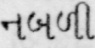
નબળી
